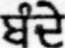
ਬੰਦੇ
